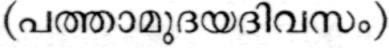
(പത്താമുദയദിവസം)
